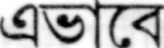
এভাবে
